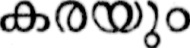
കരയും
